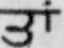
ਤਾਂ
